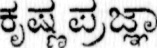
ಕೃಷ್ಣಪ್ರಜ್ಞಾ
